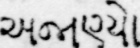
અજાણ્યે
